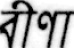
বীণা
